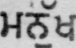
ਮਨੁੱਖ
